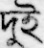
দুই
